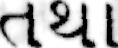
તથા
